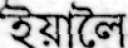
'ইয়ালৈ
